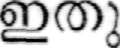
ഇതു
